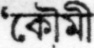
‘কৌমী
